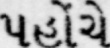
પહોંચે
